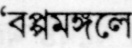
‘বপ্পমঙ্গলে
